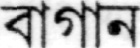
বাগান
